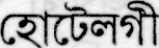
হোটেলগী
